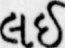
લઈ
